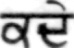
ਕਦੇ
